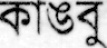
কাঙবু
